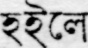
হইলে
